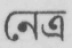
নেত্র
